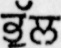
ਭੁੱਲ
